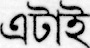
এটাই
